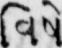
વિષે
